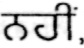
ਨਹੀਂ,
